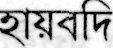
হায়বদি
